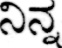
ನಿನ್ನ
